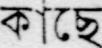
কাছে
